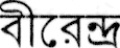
বীরেন্দ্র
